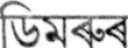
ডিমৰুৰ
